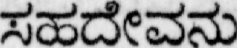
ಸಹದೇವನು
